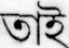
তাই
